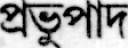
প্রভুপাদ
